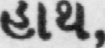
હાથ,
